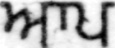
ਆਪ
